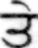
ਤੇ
